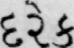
દરેક
